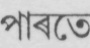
পাৰতে
